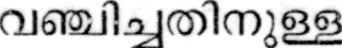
വഞ്ചിച്ചതിനുള്ള
